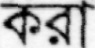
করা
